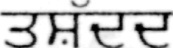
ਤਸ਼ੱਦਦ
